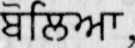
ਬੋਲਿਆ,
